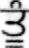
ਤੂੰ
